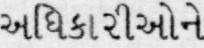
અધિકારીઓની
